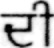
ਦੀ
